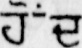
ਹੋਂਦ
